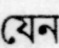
যেন
